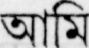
আমি
